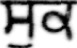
ਸੁਕ
